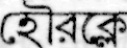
হৌরক্লে
